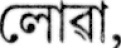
লোৱা,
